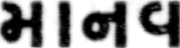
માનવ
